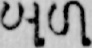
બળ
